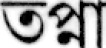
তপ্না
